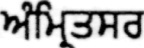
ਅੰਮ੍ਰਿਤਸਰ
